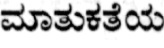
ಮಾತುಕತೆಯ
